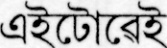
এইটোৱেই
